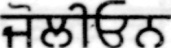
ਜੋਲੀਓਨ
